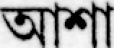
আশা
